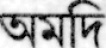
অমদি
